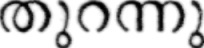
തുറന്നു
